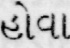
હોવા
